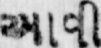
આવી
